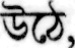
উঠে,
